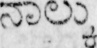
ನಾಲ್ಕು
